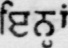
ਇਨ੍ਹਾਂ
